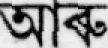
আৰু
